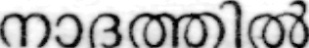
നാദത്തില്‍
